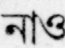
নাও
